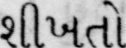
શીખતો
